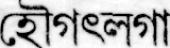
হৌগৎলগা
